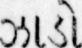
ઝાડો
